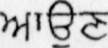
ਆਉਣ
